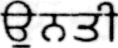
ਉਨਤੀ
